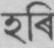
হৰি
